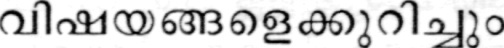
വിഷയങ്ങളെക്കുറിച്ചും
